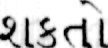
શકતો
